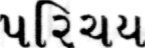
પરિચય
